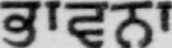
ਭਾਵਨਾ
